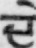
ਦੇ
